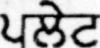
ਪਲੇਟ
